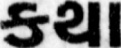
કથા
